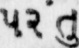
પરંતુ
